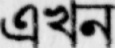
এখন
